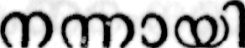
നന്നായി
